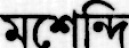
মশেন্দি
